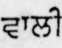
ਵਾਲੀ
